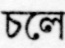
চলে
